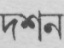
দশন
